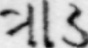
વાડ
